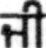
ਜੀ
